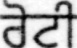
ਰੋਟੀ
